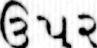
ઉપર
